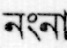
নংনা
